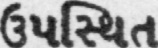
ઉપસ્થિત
